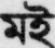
মই
